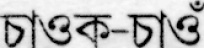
চাওক-চাওঁ
